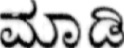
ಮಾಡಿ
